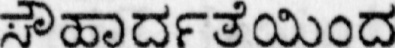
ಸೌಹಾರ್ದತೆಯಿಂದ
